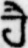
ਹੈ
